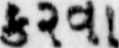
કરવા
